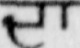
ਦਾ
